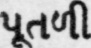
પૂતળી
